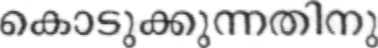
കൊടുക്കുന്നതിനു
